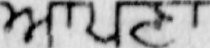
ਆਪਣਾ
